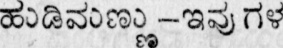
ಹುಡಿಮಣ್ಣು-ಇವುಗಳ
